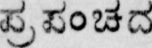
ಪ್ರಪಂಚದ
